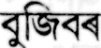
বুজিবৰ
